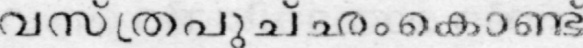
വസ്ത്രപുച്ഛംകൊണ്ട്
